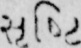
સૃષ્ટિ
